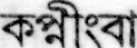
কপ্নীংবা
